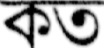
কত
